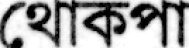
থোকপা
